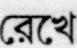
রেখে
